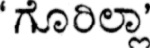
'ಗೊರಿಲ್ಲಾ'
